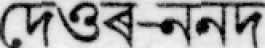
দেওৰ-ননদ
